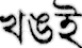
খঙই
